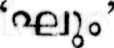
'ഘും'
